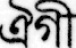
ঐগী
